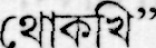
থোখি
